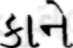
કાને
